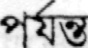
পর্যন্ত
